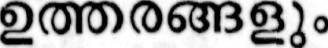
ഉത്തരങ്ങളും
